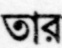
তার
